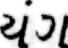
યંગ
